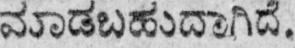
ಮಾಡಬಹುದಾಗಿದೆ.
